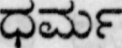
ಧರ್ಮ
